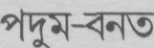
পদুম-বনত
